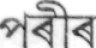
পৰীৰ
